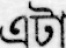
এটা
